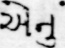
એનું
